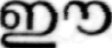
ഈ
